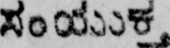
ಸಂಯುಕ್ತ
